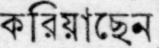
করিয়াছেন
